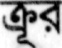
ক্রূর
